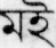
মই
